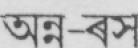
অন্ন-ৰস
